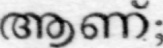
ആണ്;
